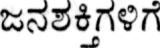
ಜನಶಕ್ತಿಗಳಿಗೆ
